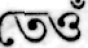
তেওঁ
